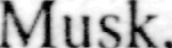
Musk,
